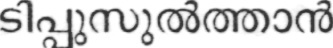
ടിപ്പുസുല്‍ത്താന്‍
